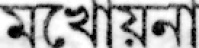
মখোয়না
